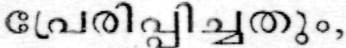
പ്രേരിപ്പിച്ചതും,
